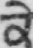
ਕੇ
